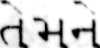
તેમને
